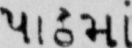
પાઠમાં
